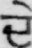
ਦੇ
